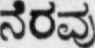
ನೆರವು
